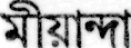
মীয়ান্দা
